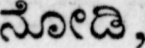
ನೋಡಿ,
